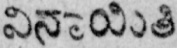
ವಿನಾಯಿತಿ
